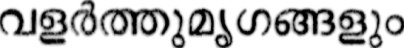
വളര്‍ത്തുമൃഗങ്ങളും
